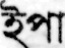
ইপা
